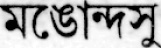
মঙোন্দসু
